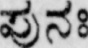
ಪುನಃ
